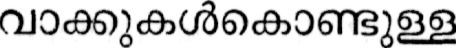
വാക്കുകള്‍കൊണ്ടുള്ള
